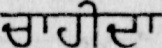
ਚਾਹੀਦਾ
